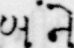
બંને
